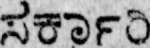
ಸರ್ಕಾರಿ
